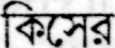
কিসের
